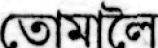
তোমালৈ
